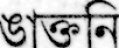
ঙাক্তনি
